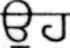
ਉਹ
